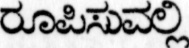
ರೂಪಿಸುವಲ್ಲಿ
